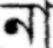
না
